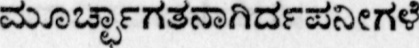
ಮೂರ್ಚ್ಛಾಗತನಾಗಿರ್ದಪನೀಗಳೆ
